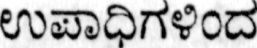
ಉಪಾಧಿಗಳಿಂದ
